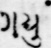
ગયું
